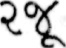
રજૂ
